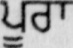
ਪੂਰਾ
